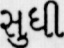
સુધી
